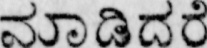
ಮಾಡಿದರೆ
